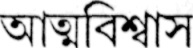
আত্মবিশ্বাস
